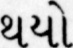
થયો
